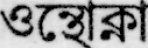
ওন্থোক্না
